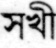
সখী
